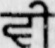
ਵੀ
